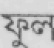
ফুল
